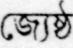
জ্যেষ্ঠ
